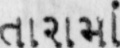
તારામાં
